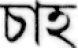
চাহ
